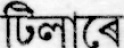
টিলাৰে
